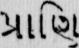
પ્રાણિ
